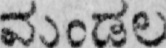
ಮಂಡಲ
